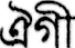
ঐগী
